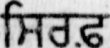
ਸਿਰਫ਼
